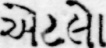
એટલો
